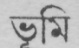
ভূমি
